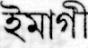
ইমাগী
